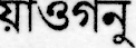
য়াওগনু
